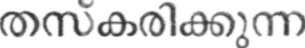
തസ്കരിക്കുന്ന
